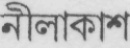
নীলাকাশ
